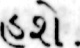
હશે.
